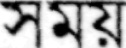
সময়
